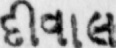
દીવાલ
